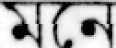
মনে
